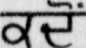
ਕਦੋਂ
